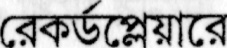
রেকর্ডপ্লেয়ারে
